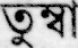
তুম্বা
